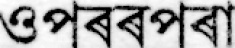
ওপৰৰপৰা
